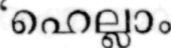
'ഹെല്ലാം
